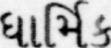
ધાર્મિક
